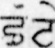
ਛੋਟੇ
